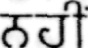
ਨਹੀਂ
